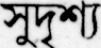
সুদৃশ্য
